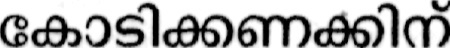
കോടിക്കണക്കിന്
